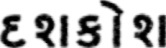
દશકોશ
